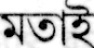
মতাই
